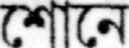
শোনে
